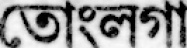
তোংলগা
